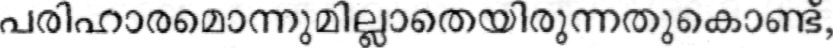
പരിഹാരമൊന്നുമില്ലാതെയിരുന്നതുകൊണ്ട്,
